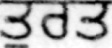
ਤੁਰਤ
